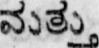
ಮತ್ತು
